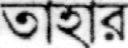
তাহার
